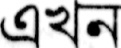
এখন
